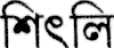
শিৎলি
